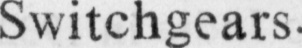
Switchgears.
